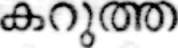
കറുത്ത
